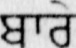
ਬਾਰੇ
